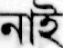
নাই
